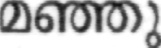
മഞ്ഞു
